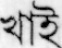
খাই
